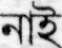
নাই
